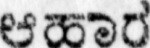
ಆಹಾರ
